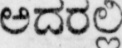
ಅದರಲ್ಲಿ
